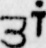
ਤਾਂ
